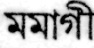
মমাগী
